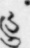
હું
